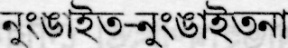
নুংঙাইত-নুংঙাইতনা
